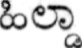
ಹಿಲ್ಡಾ
